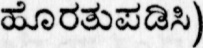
ಹೊರತುಪಡಿಸಿ)
